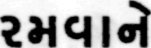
રમવાને
